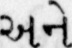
અને
